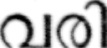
വരി
